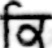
ਕਿ
